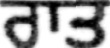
ਰਾਤ
